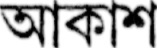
আকাশ
